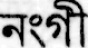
নংগী
